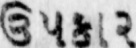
ઉપકાર
